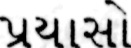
પ્રયાસો
